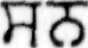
ਸਨ
